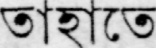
তাহাতে
